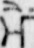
ਮੈਂ
